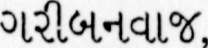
ગરીબનવાજ,
